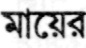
মায়ের
